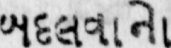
બદલવાનો
